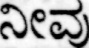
ನೀವು
